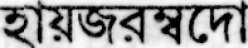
হায়জরম্বদো
